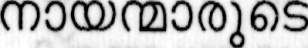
നായന്മാരുടെ
